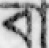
বা
